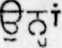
ਉਨ੍ਹਾਂ
